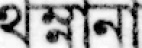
থম্নানা
